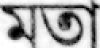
মতা
